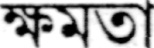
ক্ষমতা
